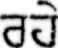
ਰਹੇ
